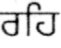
ਰਹਿ
